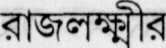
রাজলক্ষ্মীর
